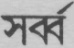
সৰ্ব্ব
